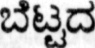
ಬೆಟ್ಟದ
